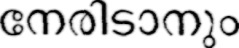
നേരിടാനും
